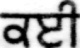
ਕਈ
